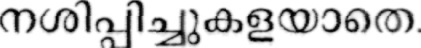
നശിപ്പിച്ചുകളയാതെ.
